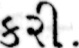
કરી.
